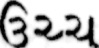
ઉચ્ચ
